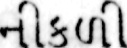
નીકળી
